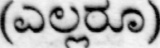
(ಎಲ್ಲರೂ)
